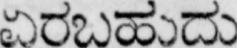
ಏರಬಹುದು
